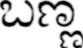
ಬಣ್ಣ
